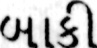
બાકી
